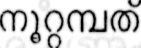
നൂറ്റമ്പത്
